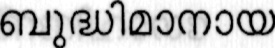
ബുദ്ധിമാനായ
